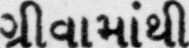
ગ્રીવામાંથી
